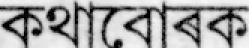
কথাবোৰক
